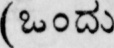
(ಒಂದು
